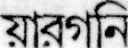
য়ারগনি
